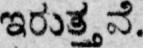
ಇರುತ್ತವೆ.
